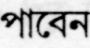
পাবেন
